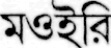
মওইরি
